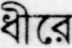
ধীরে
